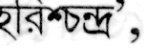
হরিশ্চন্দ্র’,
